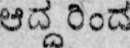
ಆದ್ದರಿಂದ
